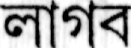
লাগব
